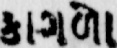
કાગળો
